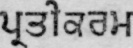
ਪ੍ਰਤੀਕਰਮ
